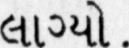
લાગ્યો.
